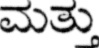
ಮತ್ತು
